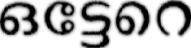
ഒട്ടേറെ
